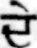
ਦੇ
